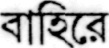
বাহিরে
